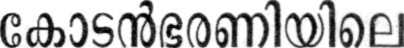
കോടന്‍ഭരണിയിലെ
